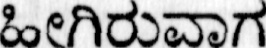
ಹೀಗಿರುವಾಗ
